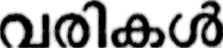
വരികള്‍
